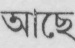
আছে
